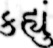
કહ્યું
